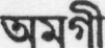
অমগী
